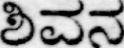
ಶಿವನ
